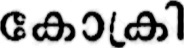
കോക്രി
